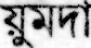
য়ুমদা
